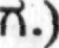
ಗ.)
